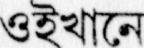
ওইখানে
